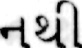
નથી
